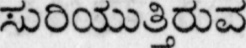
ಸುರಿಯುತ್ತಿರುವ
